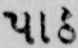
પાઠ
